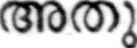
അതു
